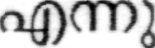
എന്നു
